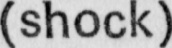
(shock)
